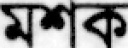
মশক
